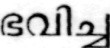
ഭവിച്ച
